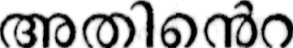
അതിന്റെ
